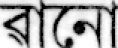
ৱানো
